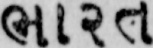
ભારત
